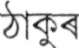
ঠাকুৰ
